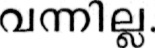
വന്നില്ല.
